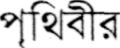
পৃথিবীর
